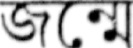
জন্মে
